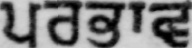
ਪਰਭਾਵ
